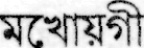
মখোয়গী
